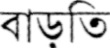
বাড়তি
